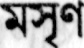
মসৃণ
